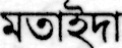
মতাইদা
